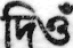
দিওঁ
